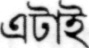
এটাই
